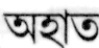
অহাত
